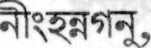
নীংহন্নগনু,
